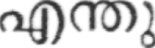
എന്തു
